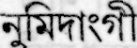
নুমিদাংগী
